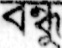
বন্ধু
